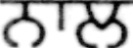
ਨਾਲ
